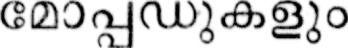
മോപ്പഡുകളും
